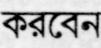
করবেন
